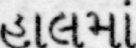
હાલમાં
